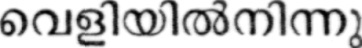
വെളിയില്‍നിന്നു
